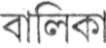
বালিকা
